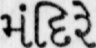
મંદિરે
